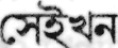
সেইখন
